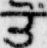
ਤੋਂ
